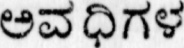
ಅವಧಿಗಳ
